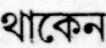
থাকেন
